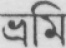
ভ্রমি
